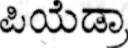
ಪಿಯೆಡ್ರಾ
